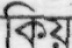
কিয়
